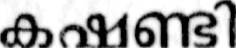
കഷണ്ടി
